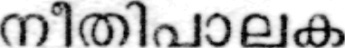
നീതിപാലക
